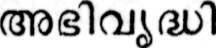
അഭിവൃദ്ധി
